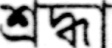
শ্রদ্ধা
